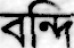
বন্দি
